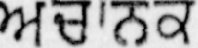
ਅਚਾਨਕ
